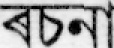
ৰচনা
